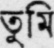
তুমি
